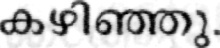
കഴിഞ്ഞു.
